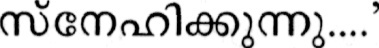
സ്നേഹിക്കുന്നു....’
